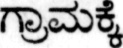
ಗ್ರಾಮಕ್ಕೆ
